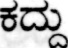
ಕದ್ದು
